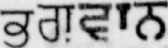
ਭਗਵਾਨ
